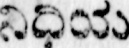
ನಿಧಿಯ
